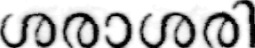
ശരാശരി
